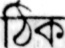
ঠিক
